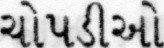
ચોપડીઓ
